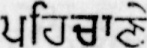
ਪਹਿਚਾਣੇ
